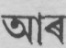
আৰ
